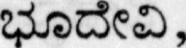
ಭೂದೇವಿ,
